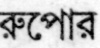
রুপোর
